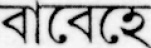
বাবেহে
